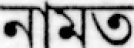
নামত
